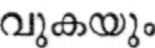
വുകയും
